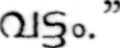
വട്ടം."
